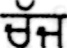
ਚੱਜ
